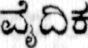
ವೈದಿಕ
